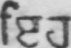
ਇਹ
